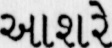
આશરે
